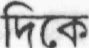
দিকে
